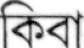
কিবা
